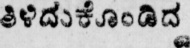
ತಿಳಿದುಕೊಂಡಿದ್ದ
